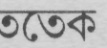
ততেক
